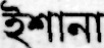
ইশানা
